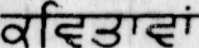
ਕਵਿਤਾਵਾਂ
